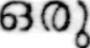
ഒരു
